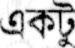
একটু
